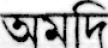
অমদি
